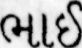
ભાઈ
